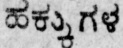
ಹಕ್ಕುಗಳ
